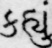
કહ્યું
